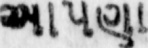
આપણા
